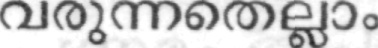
വരുന്നതെല്ലാം
